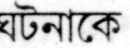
ঘটনাকে
